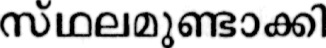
സ്ഥലമുണ്ടാക്കി
